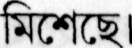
মিশেছে।
